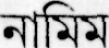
নামিম
